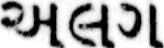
અલગ
